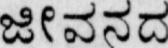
ಜೀವನದ
